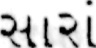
સારાં
